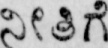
ನೀತಿಗೆ
